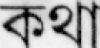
কথা
